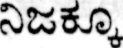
ನಿಜಕ್ಕೂ
